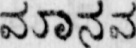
ಮಾನವ
